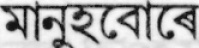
মানুহবোৰে
